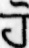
ਹੋ
